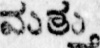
ಮತ್ತು
